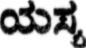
ಯಸ್ಯ
